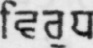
ਵਿਰੁਧ
